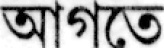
আগতে
